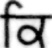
ਕਿ
